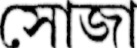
সোজা
